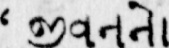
'જીવનનો
